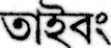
তাইবং
